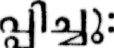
പ്പിച്ചു:
